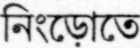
নিংড়োতে
